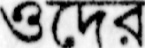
ওদের
